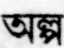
অল্প
